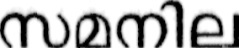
സമനില
